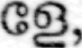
ളേ,
